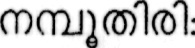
നമ്പൂതിരി:
